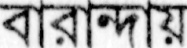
বারান্দায়
